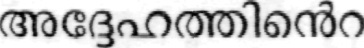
അദ്ദേഹത്തിന്റെ
